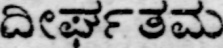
ದೀರ್ಘತಮ
